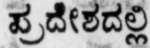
ಪ್ರದೇಶದಲ್ಲಿ
